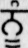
ਨੂੰ
